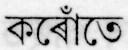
কৰোঁতে
